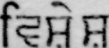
ਵਿਸ਼ੇਸ਼
